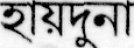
হায়দুনা
